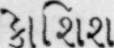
કોશિશ
